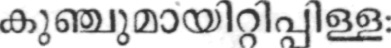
കുഞ്ചുമായിറ്റിപ്പിള്ള:
